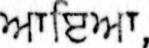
ਆਇਆ,
